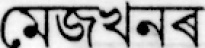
মেজখনৰ
